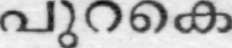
പുറകെ
